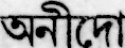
অনীদো
